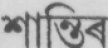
শান্তিৰ
